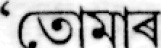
'তোমাৰ
